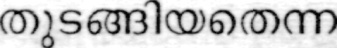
തുടങ്ങിയതെന്ന
